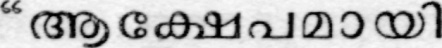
"ആക്ഷേപമായി
